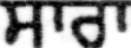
ਸਾਰਾ
